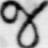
જ
